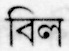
বিল
